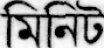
মিনিট
